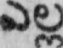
ಎಲ್ಲ
